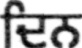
ਦਿਨ
